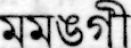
মমঙগী
